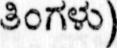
ತಿಂಗಳು)
